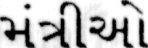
મંત્રીઓ
